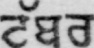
ਟੱਬਰ
